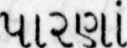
પારણાં
